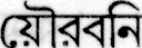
য়ৌরবনি
